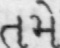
તમે
